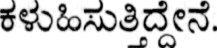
ಕಳುಹಿಸುತ್ತಿದ್ದೇನೆ.
